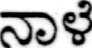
ನಾಳೆ
